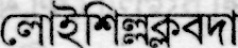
লোইশিল্লক্লবদা
